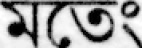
মতেং
